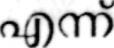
എന്ന്
